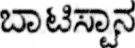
ಬಾಟಿಸ್ಟಾನ
